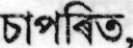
চাপৰিত,
